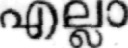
എല്ലാ
